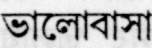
ভালোবাসা
